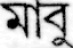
মাবু
